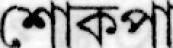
শোকপা
